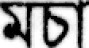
মচা
